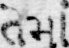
તેમાં
